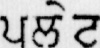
ਪਲੇਟ
